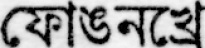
ফোঙনখ্রে
